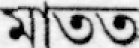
মাতত
